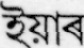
ইয়াৰ
